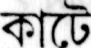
কাটে
